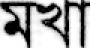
মখা
